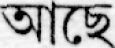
আছে
